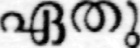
ഏതു
